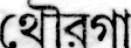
থৌরগা
